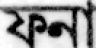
ফনা
